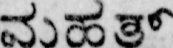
ಮಹತ್
